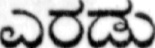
ಎರಡು
